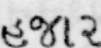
હજાર
